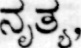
ನೃತ್ಯ,
